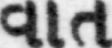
વાત
